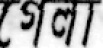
গেলা
